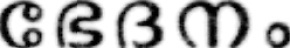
ഭേദനം
